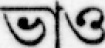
ভাও
